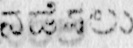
ನಡೆಸಲು
